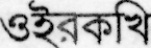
ওইরকখি
